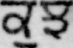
ਕੁਝ
